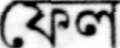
ফেল
